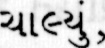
ચાલ્યું,
